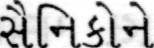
સૈનિકોને
